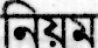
নিয়ম
